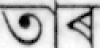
তাৰ
